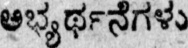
ಅಭ್ಯರ್ಥಿಗಳು
